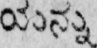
ಯನ್ನು
